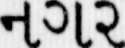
નગર
